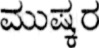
ಮುಷ್ಕರ
